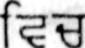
ਵਿਚ
